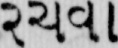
રચવા
